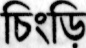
চিংড়ি
